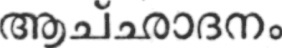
ആച്ഛാദനം
